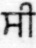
ਸੀ
